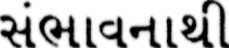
સંભાવનાથી
